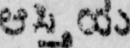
ಆಸ್ತಿಯ
